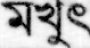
মখুৎ
